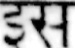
इस
